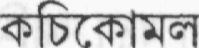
কচিকোমল
